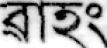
ৱাহং
